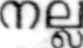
നല്ല
